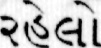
રહેલો
